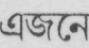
এজনে
